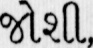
જોશી,
